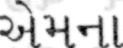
એમના
